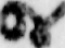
જ
